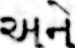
અને
